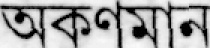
অকণমান
